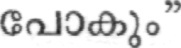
പോകും”
